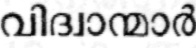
വിദ്വാന്മാര്‍
